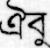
ঐবু
